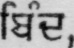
ਬਿੰਦ,
